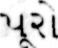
પૂરો
